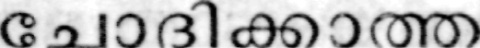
ചോദിക്കാത്ത
